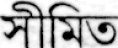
সীমিত
